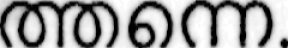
ത്തന്നെ.
